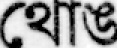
থোঙ
